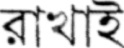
রাখাই
